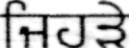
ਜਿਹੜੇ
